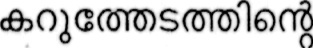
കറുത്തേടത്തിന്റെ
